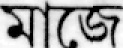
মাজে
